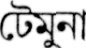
টেমুনা
